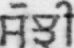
ਸੋਝੀ
